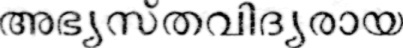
അഭ്യസ്തവിദ്യരായ
